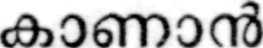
കാണാന്‍
